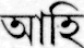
আহি
